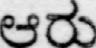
ಆರು
